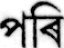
পৰি
